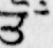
ਤੋਂ
